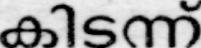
കിടന്ന്
